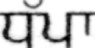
ਧੱਪਾ
